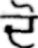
ਦੋ
